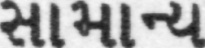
સામાન્ય
